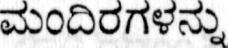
ಮಂದಿರಗಳನ್ನು
